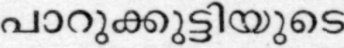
പാറുക്കുട്ടിയുടെ
